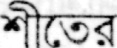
শীতের
